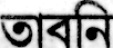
তাবনি
